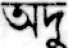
অদু
